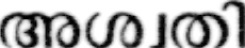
അശ്വതി
